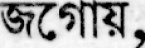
জগোয়,
